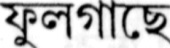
ফুলগাছে
